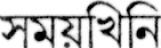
সময়খিনি
